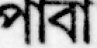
পাবা
